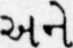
અને
